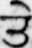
ਤੇ
